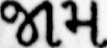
જામ
